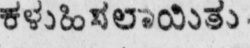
ಕಳುಹಿಸಲಾಯಿತು.
